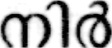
നിര്‍
